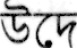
উদে
